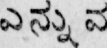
ಎನ್ನುವ
